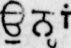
ਉਨ੍ਹਾਂ
